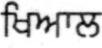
ਖਿਆਲ
